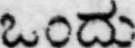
ಒಂದು
